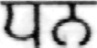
ਧਨ
